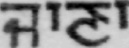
ਜਾਣਾ
